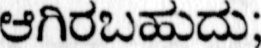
ಆಗಿರಬಹುದು;
